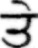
ਤੇ
